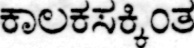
ಕಾಲಕಸಕ್ಕಿಂತ
